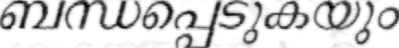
ബന്ധപ്പെടുകയും
